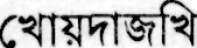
খোয়দাজখি
